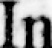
In
